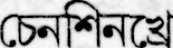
চেনশিনখ্রে
